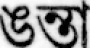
ঙন্তা
